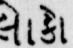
લોકો
